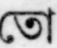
তো
